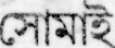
সোমাই
